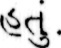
હતું.
